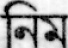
নিম
